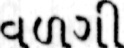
વળગી
